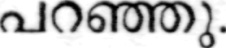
പറഞ്ഞു.
